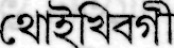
থোইখিবগী
